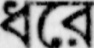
ধরে
